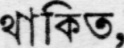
থাকিত,
